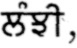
ਲੰਝੀ,
